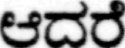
ಆದರೆ
